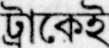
ট্রাকেই
